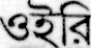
ওইরি
